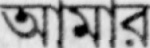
আমার
